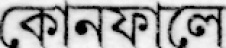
কোনফালে
